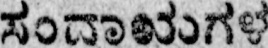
ಸಂದಾಯಗಳ
